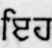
ਇਹ
